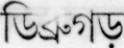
ডিব্ৰুগড়
